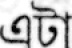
এটা
